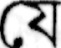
যে
